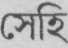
সেহি
